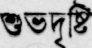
শুভদৃষ্টি
